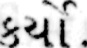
કર્યો.
